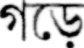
গড়ে
